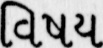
વિષય
